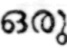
ഒരു
